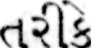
તરીકે
